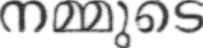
നമ്മുടെ
